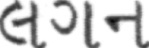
લગન
